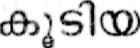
കൂടിയ
